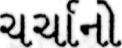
ચર્ચાનો
